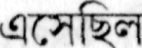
এসেছিল
